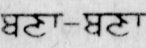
ਬਣਾ-ਬਣਾ
